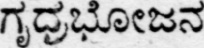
ಗೃಧ್ರಭೋಜನ
